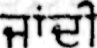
ਜਾਂਦੀ
